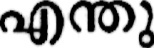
എന്തു
